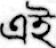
এই
